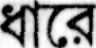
ধারে
